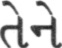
તેને
